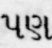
પણ
